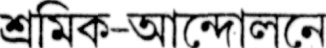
শ্রমিক-আন্দোলনে
